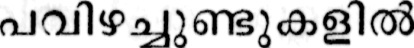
പവിഴച്ചുണ്ടുകളില്‍
